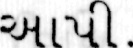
આપી.
